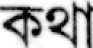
কথা
